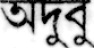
অদুবু
